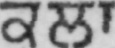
ਕਲਾ
